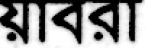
য়াবরা
